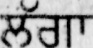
ਲੱਗਾ
